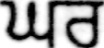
ਘਰ
